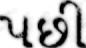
પછી
